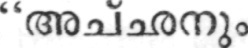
"അച്ഛനും
